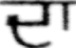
ਦਾ
